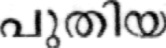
പുതിയ
